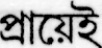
প্রায়েই
